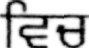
ਵਿਚ
